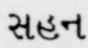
સહન
